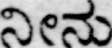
ನೀನು
